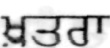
ਖ਼ਤਰਾ
